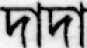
দাদা
